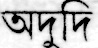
অদুদি
